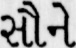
સૌને
